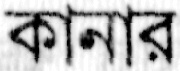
কানার
